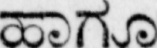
ಹಾಗೂ
